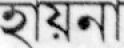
হায়না
